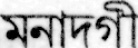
মনাদগী
